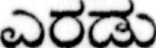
ಎರಡು
